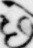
છે
